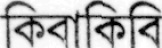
কিবাকিবি
